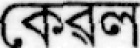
কেৱল
